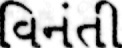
વિનંતી
